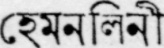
হেমনলিনী
